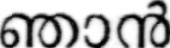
ഞാന്‍
